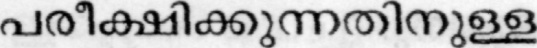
പരീക്ഷിക്കുന്നതിനുള്ള
